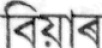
বিয়াৰ
